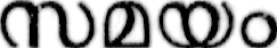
സമയം
